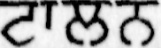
ਟਾਲਨ
